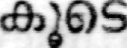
കൂടെ
